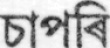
চাপৰি
